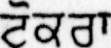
ਟੋਕਰਾ
